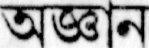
অজ্ঞান
